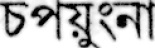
চপয়ুংনা
